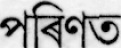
পৰিণত
